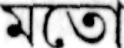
মতো
